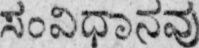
ಸಂವಿಧಾನವು
